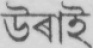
উৰাই
